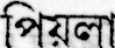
পিয়লা
